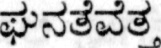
ಘನತೆವೆತ್ತ
